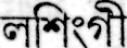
লশিংগী
